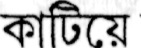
কাটিয়ে
